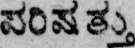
ಪರಿಷತ್ತು
